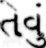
તેવું
